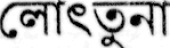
লোৎতুনা
